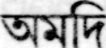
অমদি
